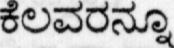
ಕೆಲವರನ್ನೂ
